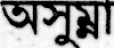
অসুম্না
